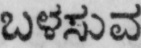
ಬಳಸುವ
